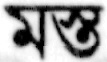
মস্ত
